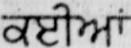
ਕਈਆਂ
